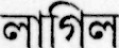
লাগিল
